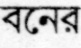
বনের
